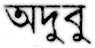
অদুবু
